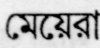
মেয়েরা
